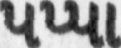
પપ્પા
